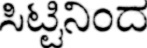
ಸಿಟ್ಟಿನಿಂದ
